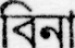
বিনা
